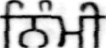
ਨਿੰਮੀ
